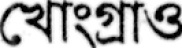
খোংগ্রাও
